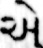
એ
